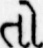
તો
